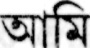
আমি
